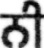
ਨੀ
